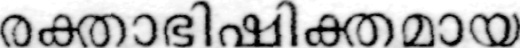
രക്താഭിഷിക്തമായ
